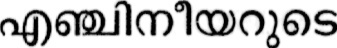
എഞ്ചിനീയറുടെ
